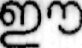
ഈ
